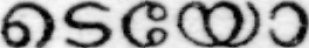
ടെയോ
